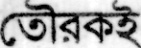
তৌরকই
